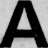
A
